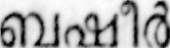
ബഷീര്‍
